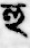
হু
